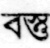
বস্তু
